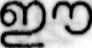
ഈ
